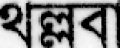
থল্লবা
